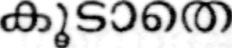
കൂടാതെ
